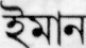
ইমান
